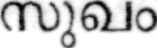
സുഖം
